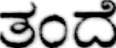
ತಂದೆ
